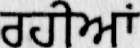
ਰਹੀਆਂ
